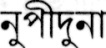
নুপীদুনা
